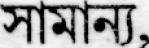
সামান্য,
